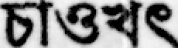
চাওখৎ
